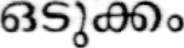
ഒടുക്കം
